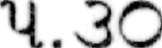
પ.૩૦
